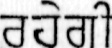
ਰਹੇਗੀ
